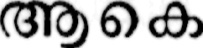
ആകെ
